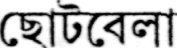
ছোটবেলা
